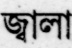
জ্বালা
